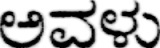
ಅವಳು
